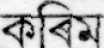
কৰিম
